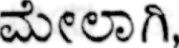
ಮೇಲಾಗಿ,
